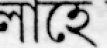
লাহে
